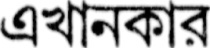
এখানকার
